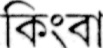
কিংবা
